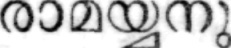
രാമയ്യനു
